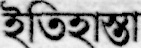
ইতিহাস্তা
